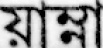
য়াম্না
